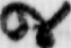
જ
